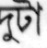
দুটা
